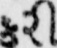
કરી
